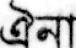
ঐনা
